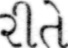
રીતે
